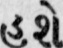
હશે
